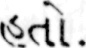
હતો.
